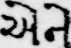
એને
